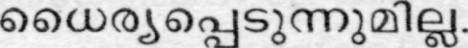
ധൈര്യപ്പെടുന്നുമില്ല.
